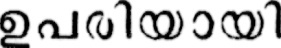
ഉപരിയായി
